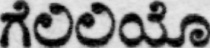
ಗೆಲಿಲಿಯೊ
